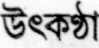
উত্কণ্ঠা
